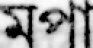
মপা
